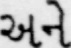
અને
